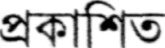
প্রকাশিত
